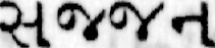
સજજન
